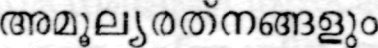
അമൂല്യരത്നങ്ങളും
